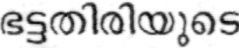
ഭട്ടതിരിയുടെ
